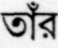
তাঁর
